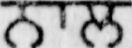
ਨਾਲ
